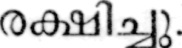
രക്ഷിച്ചു.
